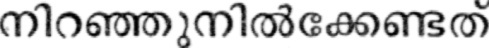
നിറഞ്ഞുനില്‍ക്കേണ്ടത്
